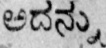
ಅದನ್ನು
